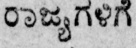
ರಾಜ್ಯಗಳಿಗೆ
